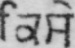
ਕਿਸੇ
